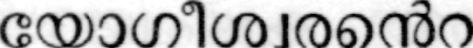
യോഗീശ്വരന്റെ
